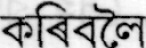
কৰিবলৈ
